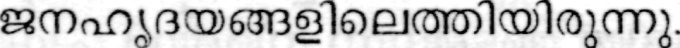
ജനഹൃദയങ്ങളിലെത്തിയിരുന്നു.
